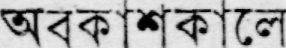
অবকাশকালে
